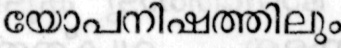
യോപനിഷത്തിലും
